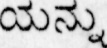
ಯನ್ನು
